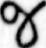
જ
